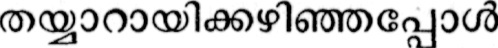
തയ്യാറായിക്കഴിഞ്ഞപ്പോള്‍
